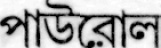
পাউরোল
